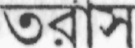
তরাস
